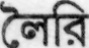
লৈরি
